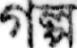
গল্প
